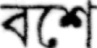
বশে
